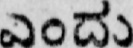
ಎಂದು
